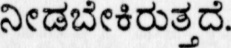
ನೀಡಬೇಕಿರುತ್ತದೆ.
